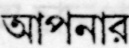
আপনার
